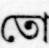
তো
